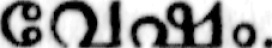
വേഷം.
